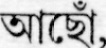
আছোঁ,
